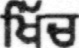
ਖਿੱਚ
